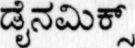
ಡೈನಮಿಕ್ಸ್
